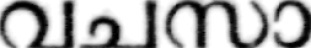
വചസാ
